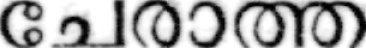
ചേരാത്ത
